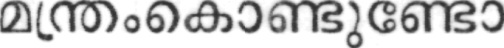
മന്ത്രംകൊണ്ടുണ്ടോ
